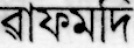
ৱাফমদি
